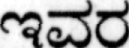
ಇವರ
